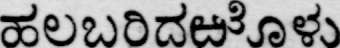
ಹಲಬರಿದಱೊಳು
